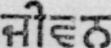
ਜੀਵਨ
